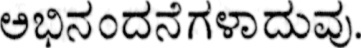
ಅಭಿನಂದನೆಗಳಾದುವು.
